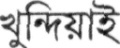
খুন্দিয়াই
